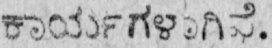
ಕಾರ್ಯಗಳಾಗಿವೆ.
